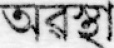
অৱস্হা
